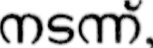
നടന്ന്,
